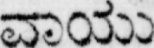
ವಾಯು
